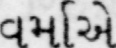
વર્માએ
